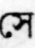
সে
